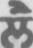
ਲੈ
